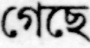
গেছে
